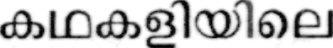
കഥകളിയിലെ
